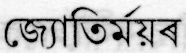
জ্যোতির্ময়ৰ
